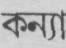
কন্যা
